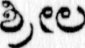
ಶ್ರೀಲ
